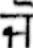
ਜੋ
